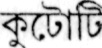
কুটোটি
